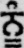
ਨੂੰ
